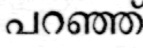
പറഞ്ഞ്
